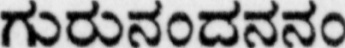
ಗುರುನಂದನನಂ
